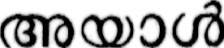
അയാള്‍
